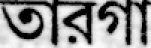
তারগা
